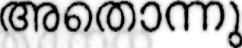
അതൊന്നു
